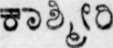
ಕಾಶ್ಮೀರಿ
